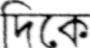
দিকে
